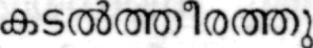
കടല്‍ത്തീരത്തു
